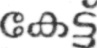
കേട്ട്
